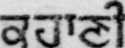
ਕਹਾਣੀ
